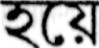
হয়ে
